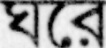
ঘরে
